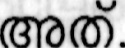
അത്.
